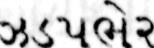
ઝડપભેર
